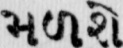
મળશે
